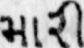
મારી
